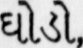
ઘોડો,
